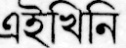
এইখিনি
